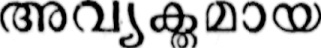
അവ്യക്തമായ
